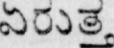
ಏರುತ್ತ
